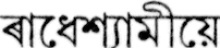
ৰাধেশ্যামীয়ে
